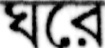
ঘরে
